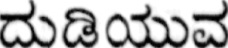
ದುಡಿಯುವ
